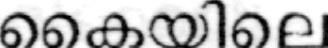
കൈയിലെ
